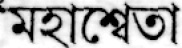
'মহাশ্বেতা
